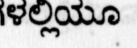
ಗಳಲ್ಲಿಯೂ
